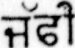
ਜੱਫੀ
